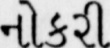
નોકરી
